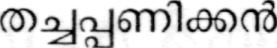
തച്ചപ്പണിക്കന്‍
